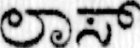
ಲಾಸ್
